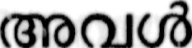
അവള്‍
